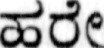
ಹರೇ
